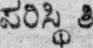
ಪರಿಸ್ಥಿತಿ
